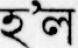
হ'ল
